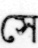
সে
